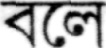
বলে
